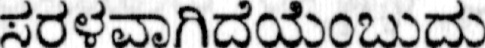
ಸರಳವಾಗಿದೆಯೆಂಬುದು
